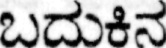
ಬದುಕಿನ
